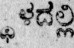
ಸ್ಥಳದಲ್ಲಿ
